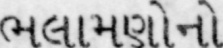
ભલામણોનો
